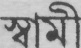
স্বামী
